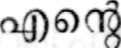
എന്റെ
